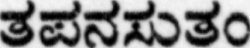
ತಪನಸುತಂ
